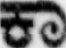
ಕಾ
